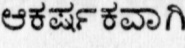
ಆಕರ್ಷಕವಾಗಿ
